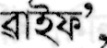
ৱাইফ’,
